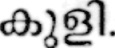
കുളി.
